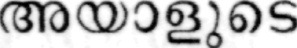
അയാളുടെ
